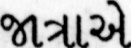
જાત્રાએ
